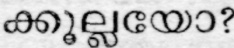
ക്കൂല്ലയോ?
